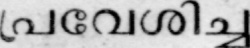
പ്രവേശിച്ച
